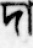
দা
